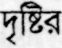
দৃষ্টির
